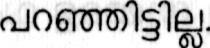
പറഞ്ഞിട്ടില്ല.
